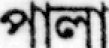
পালা
